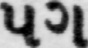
પગ
